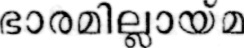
ഭാരമില്ലായ്മ
